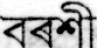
বৰশী
